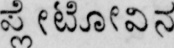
ಪ್ಲೇಟೋವಿನ
